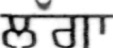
ਲੱਗਾ
